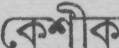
কেশীক
